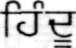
ਹਿੰਦੂ
